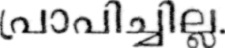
പ്രാപിച്ചില്ല.
